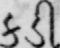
કડી
